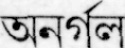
অনর্গল
